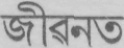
জীৱনত
